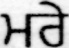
ਮਰੇ
